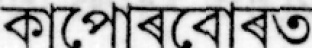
কাপোৰবোৰত
